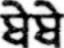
ਬੇਬੇ
